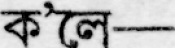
ক'লে-
